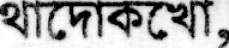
থাদোকখো,
